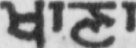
ਖਾਣਾ
